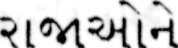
રાજાઓને
